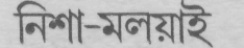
নিশা-মলয়াই
